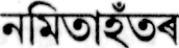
নমিতাহঁতৰ
